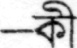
-কী
